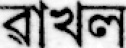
ৱাখল
